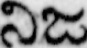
ನಿಜ
